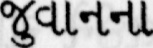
જુવાનના
